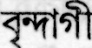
বৃন্দাগী
